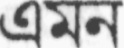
এমন
